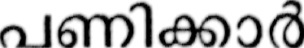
പണിക്കാര്‍
